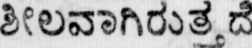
ಶೀಲವಾಗಿರುತ್ತದೆ.
